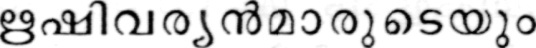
ഋഷിവര്യന്‍മാരുടെയും
